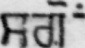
ਸਗੋਂ
